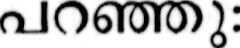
പറഞ്ഞു:
